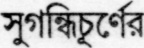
সুগন্ধিচূর্ণের
